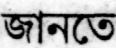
জানতে
